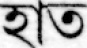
হাত
